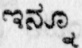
ಇನ್ನೂ
